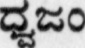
ಧ್ವಜಂ
